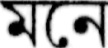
মনে
